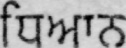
ਧਿਆਨ
